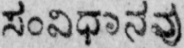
ಸಂವಿಧಾನವು
